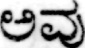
ಅವು
